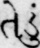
તેડું
